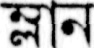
ম্লান
